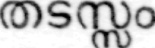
തടസ്സം
